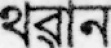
থৱান
